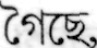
গৈছে,
